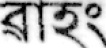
ৱাহং
